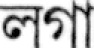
লগা
